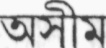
অসীম
